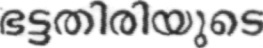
ഭട്ടതിരിയുടെ
